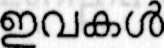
ഇവകള്‍
